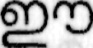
ഈ
